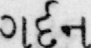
ગર્દન
